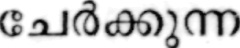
ചേര്‍ക്കുന്ന
